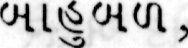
બાહુબળ,
